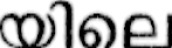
യിലെ
